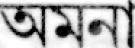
অমনা
